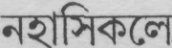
নহাসিকলে
